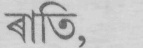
ৰাতি,
